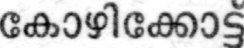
കോഴിക്കോട്ട്
